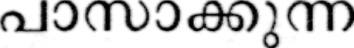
പാസാക്കുന്ന
